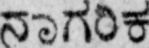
ನಾಗರಿಕ
